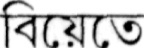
বিয়েতে
